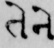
તેને
